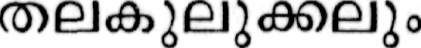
തലകുലുക്കലും
